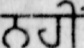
ਨਹੀਂ
